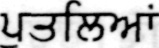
ਪੁਤਲਿਆਂ
